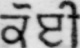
ਕੋਈ
